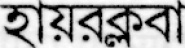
হায়রক্লবা
